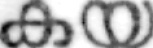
കയ
